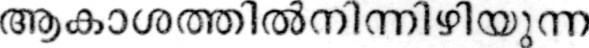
ആകാശത്തില്‍നിന്നിഴിയുന്ന
